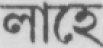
লাহে
